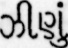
ઝીણું
